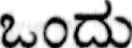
ಒಂದು
